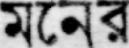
মনের
